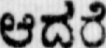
ಆದರೆ
